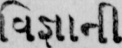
વિજ્ઞાની
